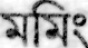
মমিং
